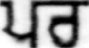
ਪਰ
